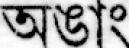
অঙাং
